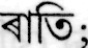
ৰাতি;
